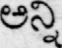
ಅನ್ನಿ
